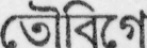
তৌবিগে
